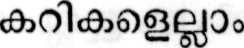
കറികളെല്ലാം
